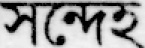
সন্দেহ
